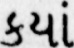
ક્યાં
